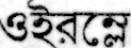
ওইরম্লে
